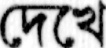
দেখে
